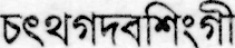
চৎথগদবশিংগী
